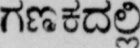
ಗಣಕದಲ್ಲಿ
